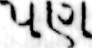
પણ
